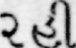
રહી
